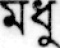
মধু
